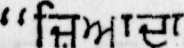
''ਜ਼ਿਆਦਾ
